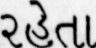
રહેતા
